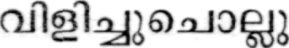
വിളിച്ചുചൊല്ലു
